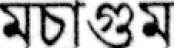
মচাগুম
